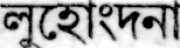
লুহোংদনা
